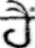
ਹੈਂ
